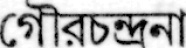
গৌরচন্দ্রনা
